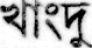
খাংদু
